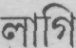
লাগি
